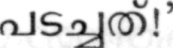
പടച്ചത്!'
